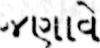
જણાવે
